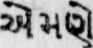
એમણે
